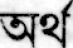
অর্থ
